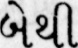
બેથી
